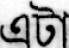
এটা
